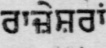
ਰਾਜ਼ੇਸ਼ਰਾਂ
